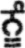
ਨੂੰ
